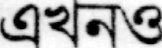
এখনও
